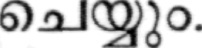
ചെയ്യും.
